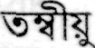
তম্বীয়ু
